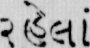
રહેલા
